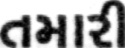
તમારી
